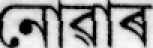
নোৱাৰ
